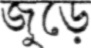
জুড়ে
